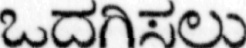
ಒದಗಿಸಲು
